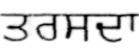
ਤਰਸਦਾ
